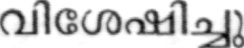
വിശേഷിച്ചു
